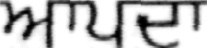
ਆਪਦਾ
